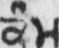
ਕੰਮ
